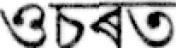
ওচৰত
